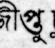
জীপ্তু
